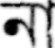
না
